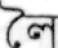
লৈ
